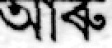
আৰু
